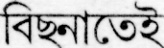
বিছনাতেই
